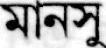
মানসু
